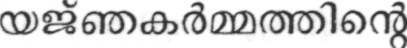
യജ്ഞകര്‍മ്മത്തിന്റെ
